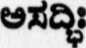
ಅಸದ್ಭಿಃ
